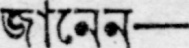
জানেন—
